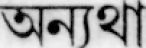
অন্যথা
